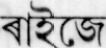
ৰাইজে
